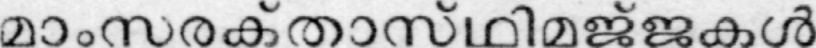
മാംസരക്താസ്ഥിമജ്ജകള്‍
